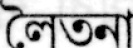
লৈতনা
